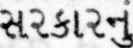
સરકારનું
